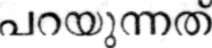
പറയുന്നത്
